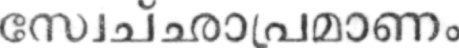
സ്വേച്ഛാപ്രമാണം
